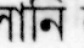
সানি
